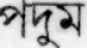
পদুম
